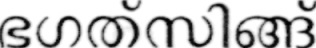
ഭഗത്സിങ്ങ്
